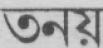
তনয়
